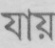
যায়
